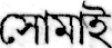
সোমাই
